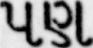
પણ
